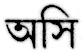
অসি
